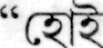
“হোই
